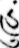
હું
